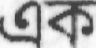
এক
